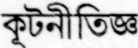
কূটনীতিজ্ঞ
